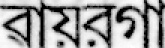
ৱায়রগা
